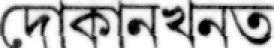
দোকানখনত
